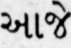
આજે
